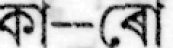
কা-ৰো
